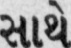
સાથે
